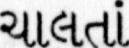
ચાલતાં
